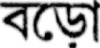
বড়ো
